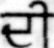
ਦੀ
